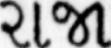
રાજા
